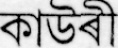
কাউৰী
